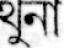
থুনা
